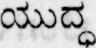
ಯುದ್ಧ
